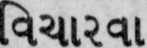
વિચારવા
